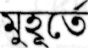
মুহূর্তে
